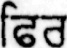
ਫਿਰ
